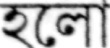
হলো
